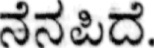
ನೆನಪಿದೆ.
